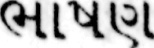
ભાષણ
